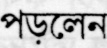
পড়লেন
